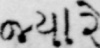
જ્યારે
